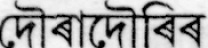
দৌৰাদৌৰিৰ
